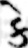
કે
